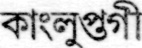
কাংলুপ্তগী
